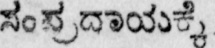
ಸಂಪ್ರದಾಯಕ್ಕೆ
